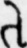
તે
